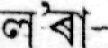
ল'ৰা-
